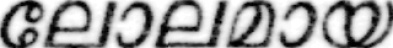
ലോലമായ
